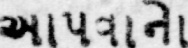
આપવાનો
